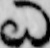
ಎ
